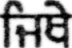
ਜਿਥੇ
